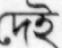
দেই
